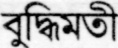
বুদ্ধিমতী
